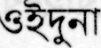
ওইদুনা
